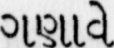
ગણાવે
